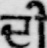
ਦੀ
